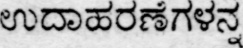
ಉದಾಹರಣೆಗಳನ್ನ
